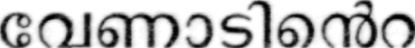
വേണാടിന്റെ
